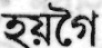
হয়গৈ
